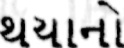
થયાનો
